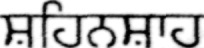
ਸ਼ਹਿਨਸ਼ਾਹ
